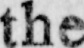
the
